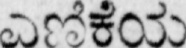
ಎಣಿಕೆಯ
